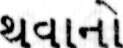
થવાનો
